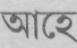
আহে
